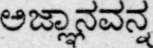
ಅಜ್ಞಾನವನ್ನ
